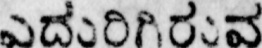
ಎದುರಿಗಿರುವ
